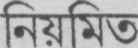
নিয়মিত
